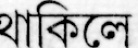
থাকিলে
